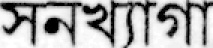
সনখ্যাগী
